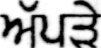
ਅੱਪੜੇ
